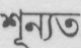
শূন্যত
